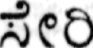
ಸೇರಿ
